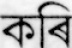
কৰি
